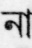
না
